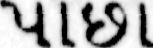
પાછા
